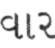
વાર
